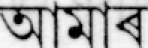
আমাৰ
